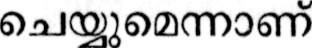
ചെയ്യുമെന്നാണ്
